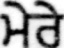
ਮੇਰੇ
